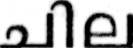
ചില
